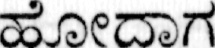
ಹೋದಾಗ
